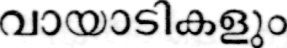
വായാടികളും
